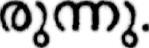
രുന്നു.
